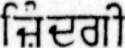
ਜ਼ਿੰਦਗੀ
